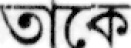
তাকে
